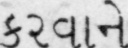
કરવાને
